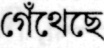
গেঁথেছে
